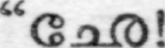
"ഛേ!
